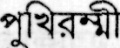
পুখিরম্মী
